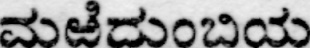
ಮಱಿದುಂಬಿಯ
